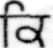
ਕਿ
